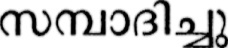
സമ്പാദിച്ചു
